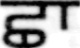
ਛਾ
